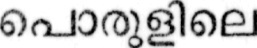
പൊരുളിലെ
